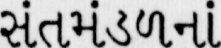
સંતમંડળનાં
